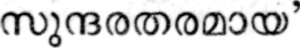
സുന്ദരതരമായ'
